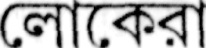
লোকেরা
